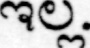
ಇಲ್ಲ.
